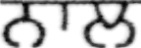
ਨਾਲ
